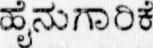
ಹೈನುಗಾರಿಕೆ
